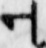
ન
